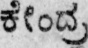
ಕೇಂದ್ರ
